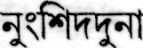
নুংশিদদুনা
